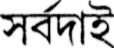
সর্বদাই
